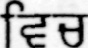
ਵਿਚ
